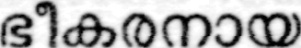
ഭീകരനായ
